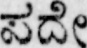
ಪದೇ
